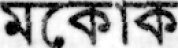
মকোক
